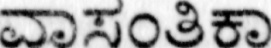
ವಾಸಂತಿಕಾ
